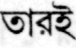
তারই
